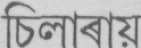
চিলাৰায়
